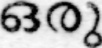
ഒരു
